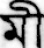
মী
